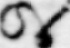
જ
